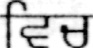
ਵਿਚ
